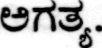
ಅಗತ್ಯ.
